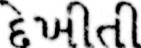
દેખીતી
